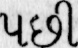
પછી
